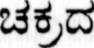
ಚಕ್ರದ
